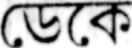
ডেকে
